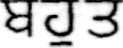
ਬਹੁਤ
